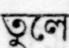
তুলে
